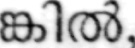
ങ്കില്‍,
